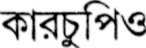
কারচুপিও
